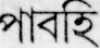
পাবহি
